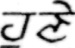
ਹੁਣੇ
